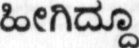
ಹೀಗಿದ್ದೂ
